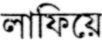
লাফিয়ে
